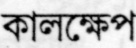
কালক্ষেপ
